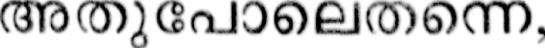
അതുപോലെതന്നെ,
